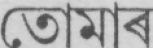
তোমাৰ
